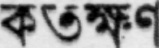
কতক্ষণ
